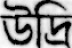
উদ্রি
